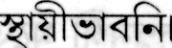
স্থায়ীভাবনি।
